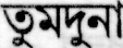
তুমদুনা
